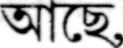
আছে,
